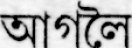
আগলৈ
